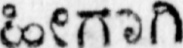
ಹೀಗಾಗಿ
